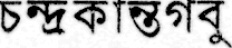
চন্দ্রকান্তগবু
